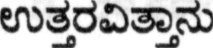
ಉತ್ತರವಿತ್ತಾನು
